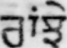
ਰਾਂਝੇ
